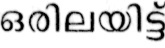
ഒരിലയിട്ട്
